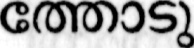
ത്തോടു
